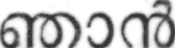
ഞാന്‍
